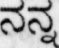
ನನ್ನ
